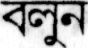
বলুন
